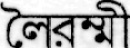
লৈরম্মী
